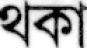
থকা
